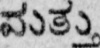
ಮತ್ತು
